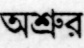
অশ্রুর
